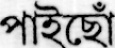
পাইছোঁ
